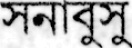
সনাবুসু
